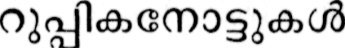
റുപ്പികനോട്ടുകള്‍
